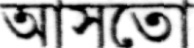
আসতো
